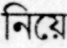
নিয়ে
